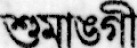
শুমাঙগী
